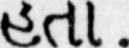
હતા.
